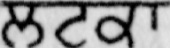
ਲਟਕਾ
